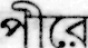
পীরে
